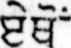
ਏਥੋਂ
